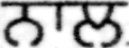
ਨਾਲ
